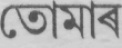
তোমাৰ
